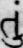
તું
